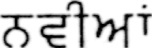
ਨਵੀਆਂ
